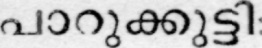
പാറുക്കുട്ടി:
